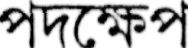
পদক্ষেপ
